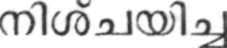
നിശ്ചയിച്ച
